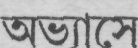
অভ্যাসে
